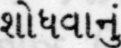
શોધવાનું
